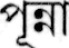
পূন্না
